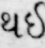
થઈ
